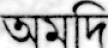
অমদি
